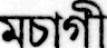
মচাগী
